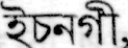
ইচনগী,
